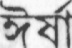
ঈর্ষা
